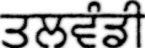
ਤਲਵੰਡੀ
